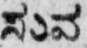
ಸುವ
